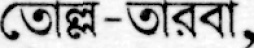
তোল্ল-তারবা,
